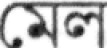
মেল
